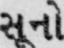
સૂનો
